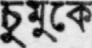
চুমুকে
